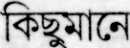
কিছুমানে
